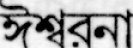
ঈশ্বরনা
